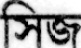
সিজ
